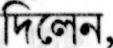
দিলেন,
